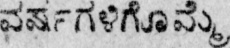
ವರ್ಷಗಳಿಗೊಮ್ಮೆ
